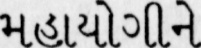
મહાયોગીને
